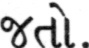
જતો.
